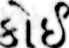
કોઈ
